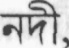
নদী,
